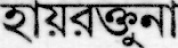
হায়রক্তুনা
